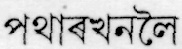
পথাৰখনলৈ
